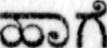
ಹಾಗೆ
